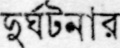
দুর্ঘটনার
